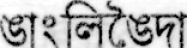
ঙাংলিঙৈদা
